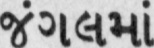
જંગલમાં
